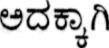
ಅದಕ್ಕಾಗಿ
